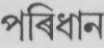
পৰিধান
